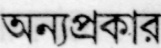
অন্যপ্রকার
